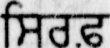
ਸਿਰਫ਼
